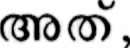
അത്,
